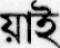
য়াই
